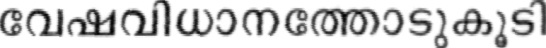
വേഷവിധാനത്തോടുകൂടി
